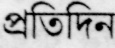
প্রতিদিন
